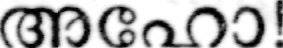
അഹോ!
